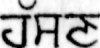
ਹੱਸਣ
